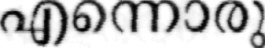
എന്നൊരു
